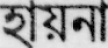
হায়না
